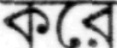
করে
